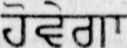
ਹੋਵੇਗਾ
